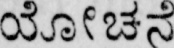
ಯೋಚನೆ
